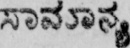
ಸಾಮಾನ್ಯ
